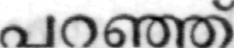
പറഞ്ഞ്
